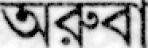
অরুবা
